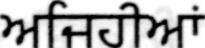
ਅਜਿਹੀਆਂ
